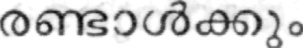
രണ്ടാള്‍ക്കും
